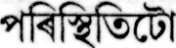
পৰিস্হিতিটো
